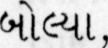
બોલ્યા,
